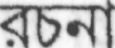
রচনা
